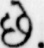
છે.
